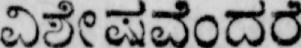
ವಿಶೇಷವೆಂದರೆ
